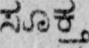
ಸೂಕ್ತ
